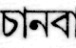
চানবা
